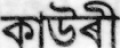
কাউৰী
